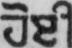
ਹੋਈ
